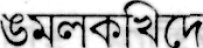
ঙমলকখিদে
